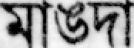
মাঙদা
